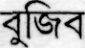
বুজিব
